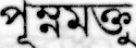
পুম্নমক্তু
